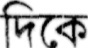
দিকে
